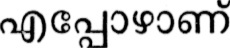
എപ്പോഴാണ്
